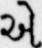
એ
